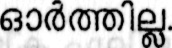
ഓര്‍ത്തില്ല.
